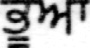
ਭੂਆ
